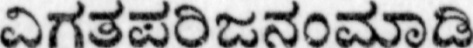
ವಿಗತಪರಿಜನಂಮಾಡಿ
